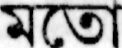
মতো
